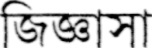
জিজ্ঞাসা
